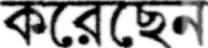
করেছেন
